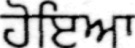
ਹੋਇਆ
